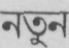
নতুন
